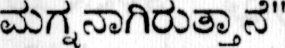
ಮಗ್ನನಾಗಿರುತ್ತಾನೆ”
